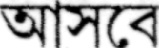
আসবে
